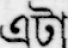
এটা
